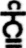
ਨੂੰ
